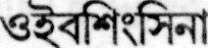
ওইবশিংসিনা
